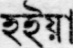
হইয়া
